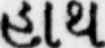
હાથ
